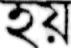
হয়
